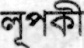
লূপকী
